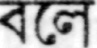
বলে
